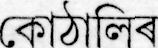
কোঠালিৰ
